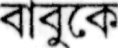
বাবুকে
